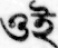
ওই
